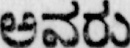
ಅವರು
